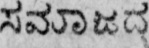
ಸಮಾಜದ
